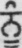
ਨੂੰ
